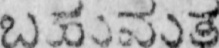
ಬಹುಮತ
